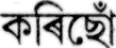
কৰিছোঁ
